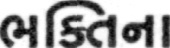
ભક્તિના
